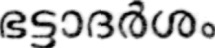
ഭട്ടാദര്‍ശം
